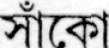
সাঁকো
